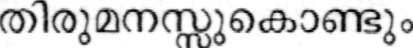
തിരുമനസ്സുകൊണ്ടും
